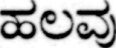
ಹಲವು
